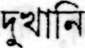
দুখানি
